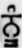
ਨੂੰ
